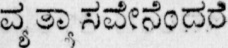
ವ್ಯತ್ಯಾಸವೇನೆಂದರೆ
